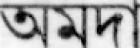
অমদা
